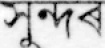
সুন্দৰ
